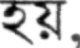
হয়,
